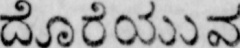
ದೊರೆಯುವ
